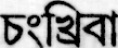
চংখ্রিবা
